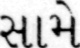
સામે
